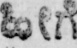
ಹೀಗೆ
